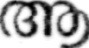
ആ
